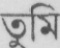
তুমি
